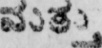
ಮತ್ತು
